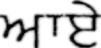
ਆਏ
